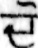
ਦੋ
